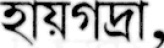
হায়গদ্রা,
